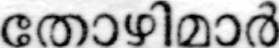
തോഴിമാര്‍
